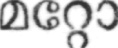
മറ്റോ
